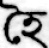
হৈ
